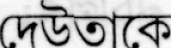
দেউতাকে
